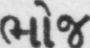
ભોજ
